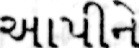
આપીને
